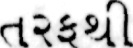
તરફથી
